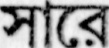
সারে
